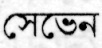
সেভেন
